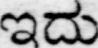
ಇದು
